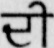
ਦੀ
